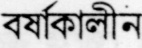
বর্ষাকালীন
